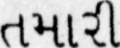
તમારી
